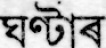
ঘণ্টাৰ
